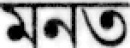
মনত
